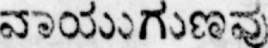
ವಾಯುಗುಣವು
